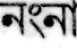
নংনা
